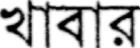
খাবার
